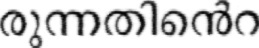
രുന്നതിന്റെ
